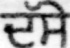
ਦੱਸੇ
